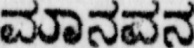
ಮಾನವನ
